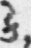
કે,
